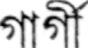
গার্গী
